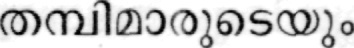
തമ്പിമാരുടെയും
